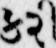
કરી
